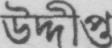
উদ্দীপ্ত
